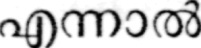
എന്നാല്‍
